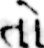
તો
